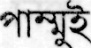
পাম্মুই
